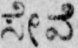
ಸೇವೆ
